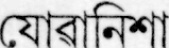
যোৱানিশা
